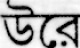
উরে
